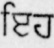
ਇਹ
